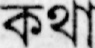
কথা
